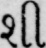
શી
